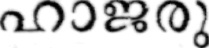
ഹാജരു
